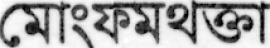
মোংফমথক্তা
